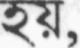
হয়,
